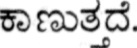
ಕಾಣುತ್ತದೆ.
